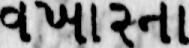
વખારના
